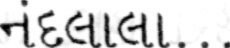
નંદલાલા...
